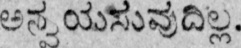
ಅನ್ವಯಸುವುದಿಲ್ಲ.
